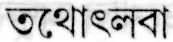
তখোৎলবা
